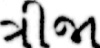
ત્રીજા
